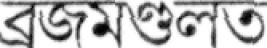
ব্রজমণ্ডলত
